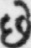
છે
